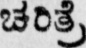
ಚರಿತ್ರೆ
